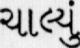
ચાલ્યું
